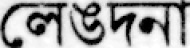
লেঙদনা
